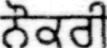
ਨੌਕਰੀ
